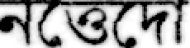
নত্তেদো
